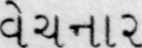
વેચનાર
